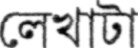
লেখাটা
